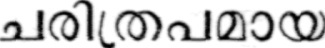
ചരിത്രപമായ
